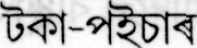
টকা-পইচাৰ
